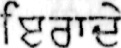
ਇਰਾਦੇ
